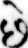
છે
